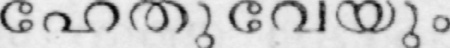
ഹേതുവേയും
